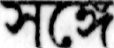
সঙ্গে
